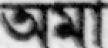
অমা
